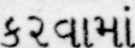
કરવામાં
